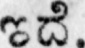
ಇದೆ.
